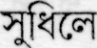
সুধিলে
